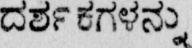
ದರ್ಶಕಗಳನ್ನು
